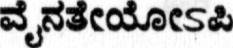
ವೈನತೇಯೋsಪಿ
